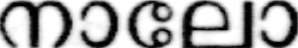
നാലോ
